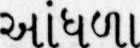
આંધળા
